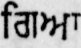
ਗਿਆ
